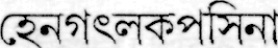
হেনগৎলকপসিনা
